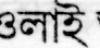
ওলাই
